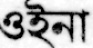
ওইনা
